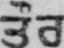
ਤੌਰ
